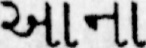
આના
